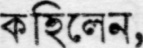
কহিলেন,
